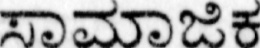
ಸಾಮಾಜಿಕ
